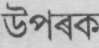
উপৰক
